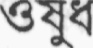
ওষুধ
